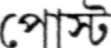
পোস্ট
